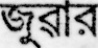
জুৱার
